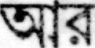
আর
